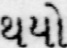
થયો
